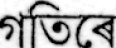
গতিৰে
